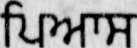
ਪਿਆਸ
